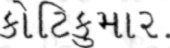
કોટિકુમાર.
